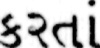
કરતાં
